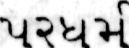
પરધર્મ
